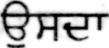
ਉਸਦਾ
